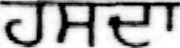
ਹਸਦਾ
